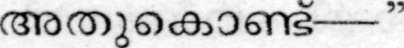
അതുകൊണ്ട്-''
